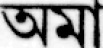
অমা
